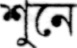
শুনে
